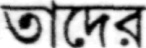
তাদের
